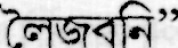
লৈজবনি”
